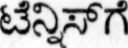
ಟೆನ್ನಿಸ್‌ಗೆ
